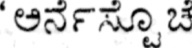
‘ಅರ್ನೆಸ್ಟೊಚೆ
